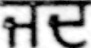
ਜਦ
